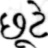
છૂટે
